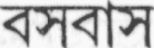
বসবাস
